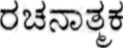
ರಚನಾತ್ಮಕ
